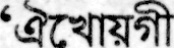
‘ঐখোয়গী
